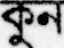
কুন
